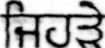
ਜਿਹੜੇ
